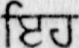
ਇਹ
